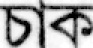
চাক
